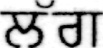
ਲੱਗ
